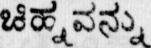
ಚಿಹ್ನವನ್ನು
